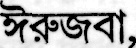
ঈরুজবা,
